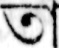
তা
